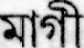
মাগী
